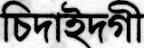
চিদাইদগী
